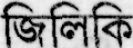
জিলিকি
